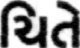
ચિતે
